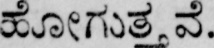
ಹೋಗುತ್ತವೆ.
